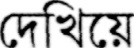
দেখিয়ে
